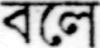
বলে
